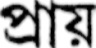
প্রায়
